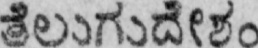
ತೆಲುಗುದೇಶಂ
